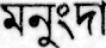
মনুংদা
